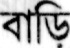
বাড়ি
